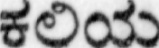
ಕಲಿಯ
